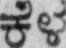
ಕೆಳ
